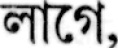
লাগে,
